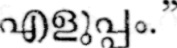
എളുപ്പം."
